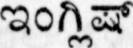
ಇಂಗ್ಲಿಷ್
